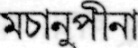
মচানুপীনা
